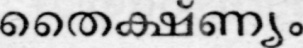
തൈക്ഷ്ണ്യം
